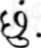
છું.
